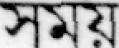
সময়
